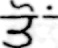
ਤੋਂ
